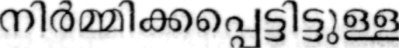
നിര്‍മ്മിക്കപ്പെട്ടിട്ടുള്ള
